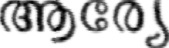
ആര്യേ
